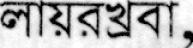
লায়রখ্রবা,
